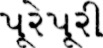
પૂરેપૂરી
